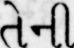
તેની
